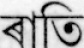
ৰাতি
